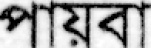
পায়বা
